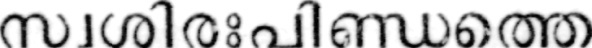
സ്വശിരഃപിണ്ഡത്തെ
